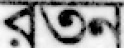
রতন
